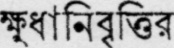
ক্ষুধানিবৃত্তির
